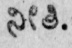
ನೀತಿ.
